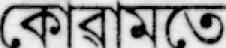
কোৱামতে
